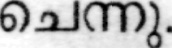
ചെന്നു.
